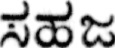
ಸಹಜ
